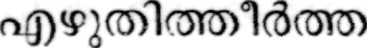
എഴുതിത്തീര്‍ത്ത
